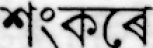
শংকৰে
